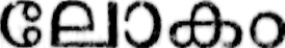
ലോകം
